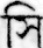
সি
